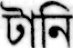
টানি
